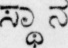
ಸ್ಥಾನ
